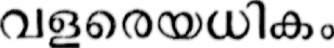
വളരെയധികം
